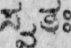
ಸ್ವತಃ
